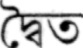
দ্বৈত
